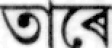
তাৰে
